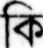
কি
